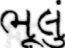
ભૂલું
